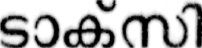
ടാക്സി
